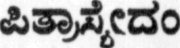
ಪಿತ್ರಾಸ್ಯೇದಂ
